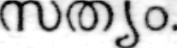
സത്യം.
